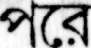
পরে
